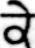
ਕੇ
